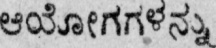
ಆಯೋಗಗಳನ್ನು
